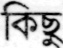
কিছু
